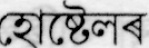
হোষ্টেলৰ
